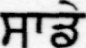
ਸਾਡੇ
